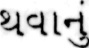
થવાનું
